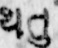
થતું
